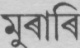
মুৰাৰি
